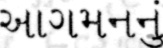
આગમનનું
